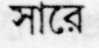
সারে
